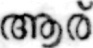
ആര്
